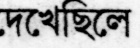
দেখেছিলে
